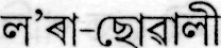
ল'ৰা-ছোৱালী
